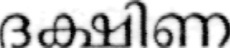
ദക്ഷിണ
